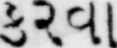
કરવા
